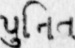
પુનિત
